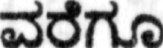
ವರೆಗೂ
